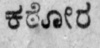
ಕಠೋರ
